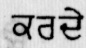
ਕਰਦੇ
